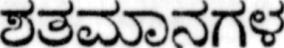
ಶತಮಾನಗಳ
